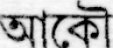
আকৌ
